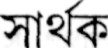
সার্থক
